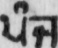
ਪੰਜ
